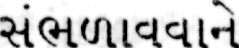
સંભળાવવાને
